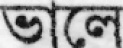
ভালে
